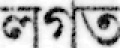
লগত
